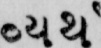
વ્યર્થ
